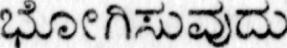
ಭೋಗಿಸುವುದು
